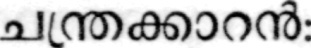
ചന്ത്രക്കാറന്‍:
